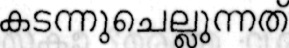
കടന്നുചെല്ലുന്നത്
